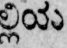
ಲ್ಲಿಯ
